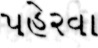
પહેરવા
